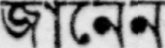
জানেন
